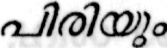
പിരിയും
